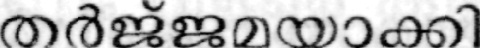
തര്‍ജ്ജമയാക്കി
